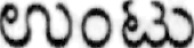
ಉಂಟು
